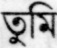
তুমি
